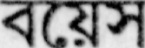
বয়েস
